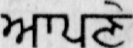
ਆਪਣੇ
